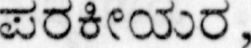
ಪರಕೀಯರ,
